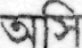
অসি
